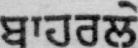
ਬਾਹਰਲੇ
